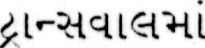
ટ્રાન્સવાલમાં
